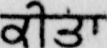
ਕੀਤਾ
